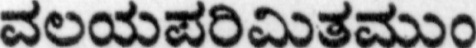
ವಲಯಪರಿಮಿತಮುಂ
